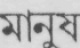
মানুষ
